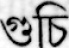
গুচি
